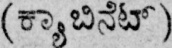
(ಕ್ಯಾಬಿನೆಟ್)
